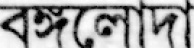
বঙ্গলোদা
